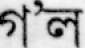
গ'ল
